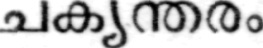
ചക്യന്തരം
